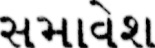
સમાવેશ
